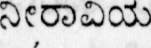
ನೀರಾವಿಯ
